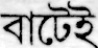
বাটেই
